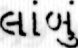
લાંબું
